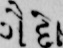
ગૈદો
